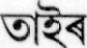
তাইৰ
